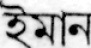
ইমান
